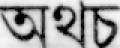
অথচ
